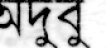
অদুবু
